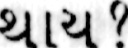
થાય?
